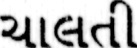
ચાલતી
